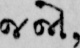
જજો,
